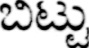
ಬಿಟ್ಟು
